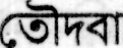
তৌদবা
